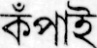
কঁপাই
